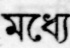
মধ্যে
